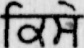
ਕਿਸੇ
